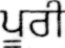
ਪੂਰੀ
